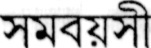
সমবয়সী
